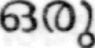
ഒരു
